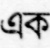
এক
